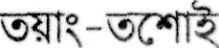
তয়াং-তশোই
